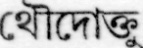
থৌদোক্তু
